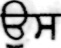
ਉਸ
